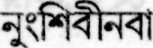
নুংশিবীনবা
